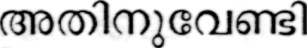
അതിനുവേണ്ടി
